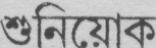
শুনিয়োক
